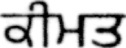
ਕੀਮਤ
